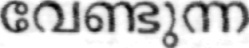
വേണ്ടുന്ന
